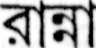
রান্না
